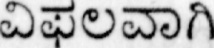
ವಿಫಲವಾಗಿ
